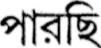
পারছি
